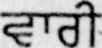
ਵਾਰੀ
